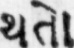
થતો
